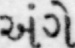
અંગે
